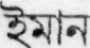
ইমান
